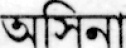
অসিনা
